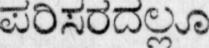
ಪರಿಸರದಲ್ಲೂ
